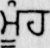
ਮੂੰਹ
